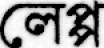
লেপ্প
